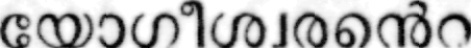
യോഗീശ്വരന്റെ
